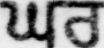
ਘਰ
